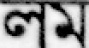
লম
